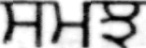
ਸਮਝ
